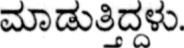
ಮಾಡುತ್ತಿದ್ದಳು.
